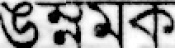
ঙম্নমক
